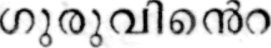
ഗുരുവിന്റെ
